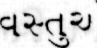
વસ્તુઓ
